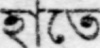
হাতে
